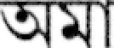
অমা
